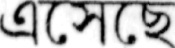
এসেছে
